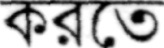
করতে
